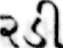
રડી
